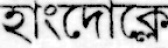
হাংদোক্লে
